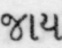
જાય
